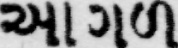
આગળ
